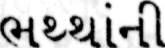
ભથ્થાંની
